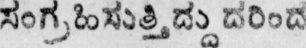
ಸಂಗ್ರಹಿಸುತ್ತಿದ್ದುದರಿಂದ
